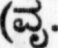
(ವೃ.
